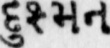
દુશ્મન
